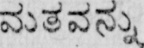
ಮತವನ್ನು
